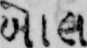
બોલ
